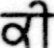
ਕੀ
